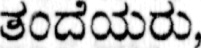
ತಂದೆಯರು,
